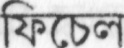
ফিচেল
